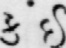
કંઈ
